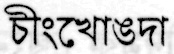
চীংখোঙদা
